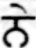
ਨੇ
